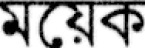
ময়েক
